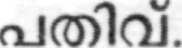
പതിവ്.
